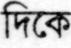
দিকে
